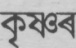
কৃষ্ণৰ
